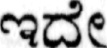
ಇದೇ
